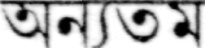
অন্যতম
